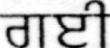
ਗਈ
